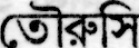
তৌরুসি
